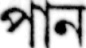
পান
